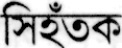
সিহঁতক
